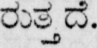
ರುತ್ತದೆ.
